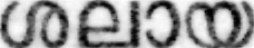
ശലായ
